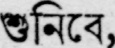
শুনিবে,
